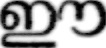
ഈ
